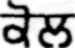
ਕੋਲ
